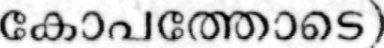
കോപത്തോടെ)
